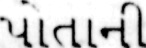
પોતાની
